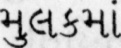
મુલકમાં
